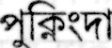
পুক্নিংদা
